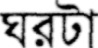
ঘরটা
